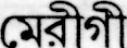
মেরীগী
